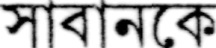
সাবানকে
